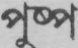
পুষ্প
